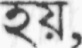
হয়,
